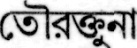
তৌরক্তুনা
